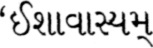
'ઈશાવાસ્યમ્
